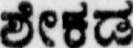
ಶೇಕಡ
